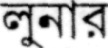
লুনার
